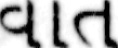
વાત
